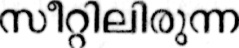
സീറ്റിലിരുന്ന
